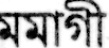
মমাগী
